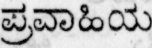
ಪ್ರವಾಹಿಯ
